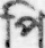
পি
